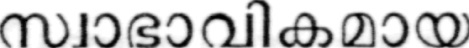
സ്വാഭാവികമായ
